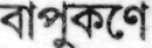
বাপুকণে
